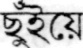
ছুঁইয়ে
